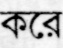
করে
